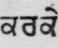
ਕਰਕੇ
